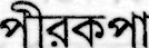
পীরকপা
